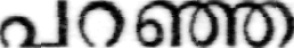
പറഞ്ഞ
